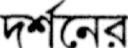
দর্শনের
